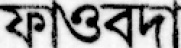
ফাওবদা
